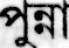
পুন্না
